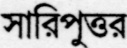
সারিপুত্তর
